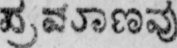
ಪ್ರಮಾಣವು
